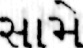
સામે
